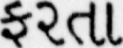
ફરતા
